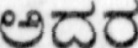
ಅದರ
